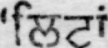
'ਲਿਟਾਂ
